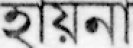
হায়না
